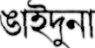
ঙাইদুনা
